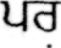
ਪਰ
